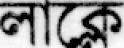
লাক্লে
